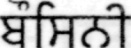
ਬੌਸਿਨੀ
